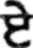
ਏ
